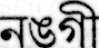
নঙগী
